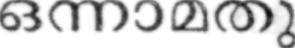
ഒന്നാമതു
